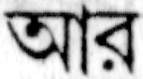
আর
